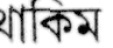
থাকিম
